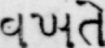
વખતે
